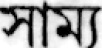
সাম্য
